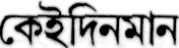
কেইদিনমান
